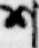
শ
